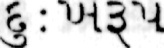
દુઃખરૂપ
